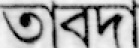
তাবদা
